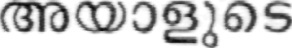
അയാളുടെ
